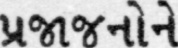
પ્રજાજનોને
